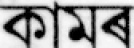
কামৰ
